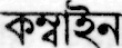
কম্বাইন
